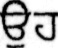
ਉਹ
